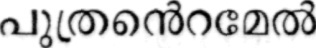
പുത്രന്റെമേല്‍
